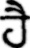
ਹੈ
